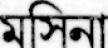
মসিনা
